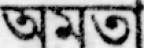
অমতা
